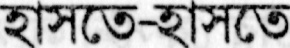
হাসতে-হাসতে
